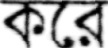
করে
